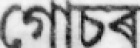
গোচৰ
